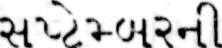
સપ્ટેમ્બરની
